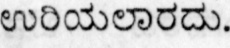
ಉರಿಯಲಾರದು.
